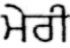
ਮੇਰੀ
